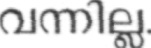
വന്നില്ല.
